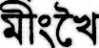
মীংখৈ
